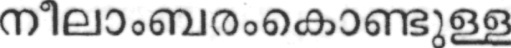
നീലാംബരംകൊണ്ടുള്ള
